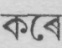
কৰে
